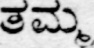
ತಮ್ಮ
